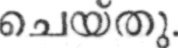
ചെയ്തു.
